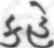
કહે
